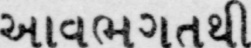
આવભગતથી
